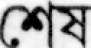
শেষ
